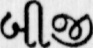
બીજી
